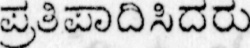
ಪ್ರತಿಪಾದಿಸಿದರು
